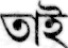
তাই
